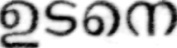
ഉടനെ
